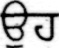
ਉਹ
